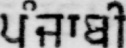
ਪੰਜਾਬੀ
